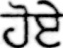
ਹੋਏ
